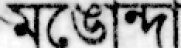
মঙোন্দা
